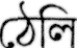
ঠেলি
